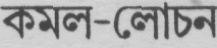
কমল-লোচন
